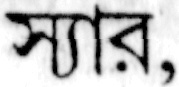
স্যার,
